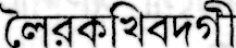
লৈরকখিবদগী
